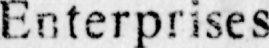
Enterprises
